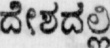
ದೇಶದಲ್ಲಿ
